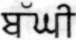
ਬੱਘੀ
